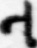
ન
